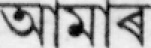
আমাৰ
